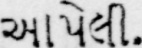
આપેલી.
